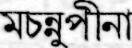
মচন্নুপীনা
